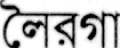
লৈরগা
